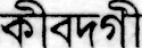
কীবদগী
